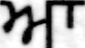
ਆ
